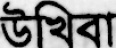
উখিবা
